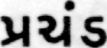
પ્રચંડ
